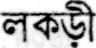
লকড়ী
